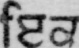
ਇਕ
